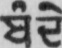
ਬੰਦੇ
